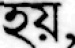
হয়,
